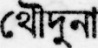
থৌদুনা
